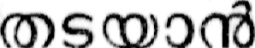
തടയാന്‍
